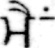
ਮੈਂ
